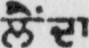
ਲੈਂਦਾ
